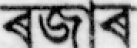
ৰজাৰ
